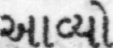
આવ્યો
